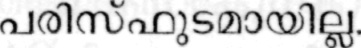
പരിസ്ഫുടമായില്ല.
